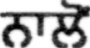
ਨਾਲੋਂ
